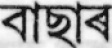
বাছাৰ
